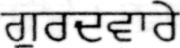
ਗੁਰਦਵਾਰੇ
